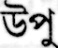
উপু
